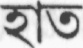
হাত
